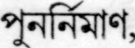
পুনর্নিমাণ,
